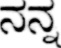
ನನ್ನ
